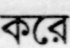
করে
